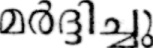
മര്‍ദ്ദിച്ചു
